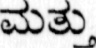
ಮತ್ತು
